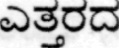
ಎತ್ತರದ
